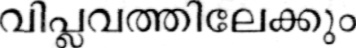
വിപ്ലവത്തിലേക്കും
